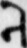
ને
